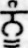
ਨੂੰ
